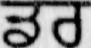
ਡਰ
